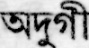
অদুগী
